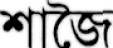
শাজৈ
